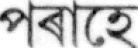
পৰাহে
